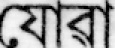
যোৱা
